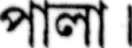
পালা।
